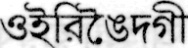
ওইরিঙৈদগী
